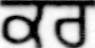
ਕਰ
